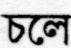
চলে
